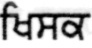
ਖਿਸਕ
